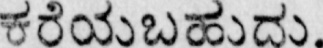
ಕರೆಯಬಹುದು.
